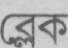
ব্লেক
